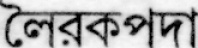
লৈরকপদা
